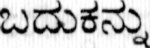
ಬದುಕನ್ನು
